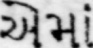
એમાં
